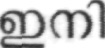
ഇനി
